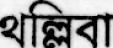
থল্লিবা
